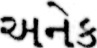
અનેક
